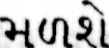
મળશે
